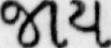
જાય
